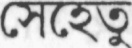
সেহেতু
